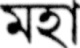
মহা
